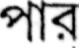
পার
